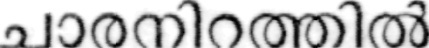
ചാരനിറത്തില്‍
